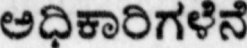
ಅಧಿಕಾರಿಗಳೆನೆ
